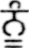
ਨੂੰ
